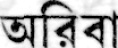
অরিবা
